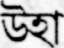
উহা
